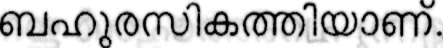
ബഹുരസികത്തിയാണ്.
